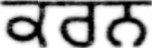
ਕਰਨ
